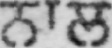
ਨਾਲ
